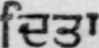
ਦਿਤਾ
